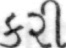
કરી
